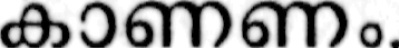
കാണണം.
